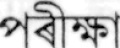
পৰীক্ষা
